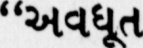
"અવધૂત
